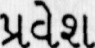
પ્રવેશ
